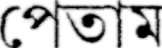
পেতাম
